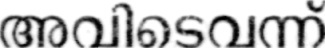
അവിടെവന്ന്
